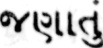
જણાતું
